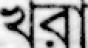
খরা
